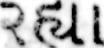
રહ્યા
